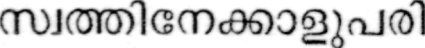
സ്വത്തിനേക്കാളുപരി
